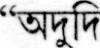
“অদুদি
